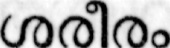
ശരീരം
